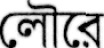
লৌরে
